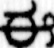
ಈ
